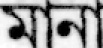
মানা
